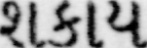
શકાય
